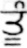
ਤੂੰ
